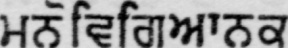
ਮਨੋਵਿਗਿਆਨਕ
